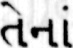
તેનાં
